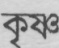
কৃষ্ণ
